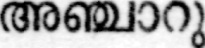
അഞ്ചാറു
